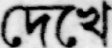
দেখে
